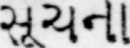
સૂચના
